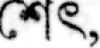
শেৎ,
